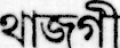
থাজগী
